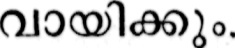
വായിക്കും.
